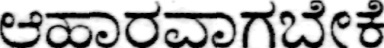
ಆಹಾರವಾಗಬೇಕೆ
